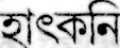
হাৎকনি
